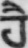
ਹੈ
